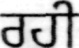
ਰਹੀ
